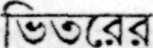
ভিতরের
